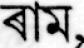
ৰাম,
